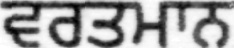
ਵਰਤਮਾਨ
